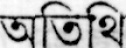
অতিথি
